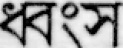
ধ্বংস
